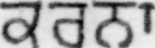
ਕਰਨਾ
